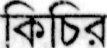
কিচির
